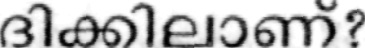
ദിക്കിലാണ്?
